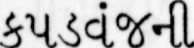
કપડવંજની
